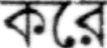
করে
